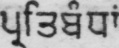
ਪ੍ਰਤਿਬੰਧਾਂ
